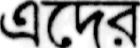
এদের
